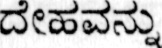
ದೇಹವನ್ನು
